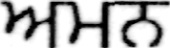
ਅਮਨ
